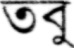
তবু
